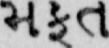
મફત
